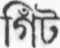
গিঁট
